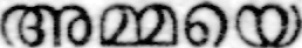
അമ്മയെ
